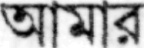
আমার
